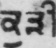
ਕੁੜੀ
